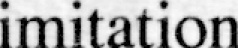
imitation
